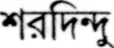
শরদিন্দু
